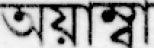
অয়াম্বা
